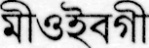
মীওইবগী
